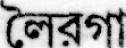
লৈরগা
